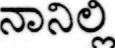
ನಾನಿಲ್ಲಿ
